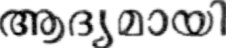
ആദ്യമായി
